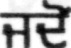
ਜਦੋਂ
